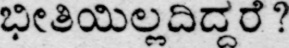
ಭೀತಿಯಿಲ್ಲದಿದ್ದರೆ?
